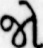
જો
